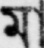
মা
